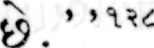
છે."૧૨૮
